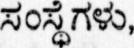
ಸಂಸ್ಥೆಗಳು,
